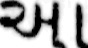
આ
